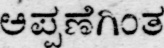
ಅಪ್ಪಣೆಗಿಂತ
